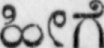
ಹೀಗೆ
